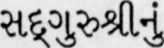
સદગુરુશ્રીનું
